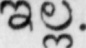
ಇಲ್ಲ.
